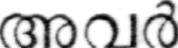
അവര്‍
